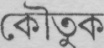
কৌতুক
